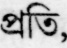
প্রতি,
